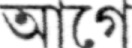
আগে
